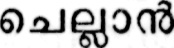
ചെല്ലാന്‍
